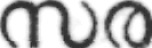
സര
